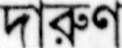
দারুণ
